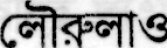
লৌরুলাও
